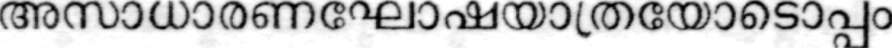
അസാധാരണഘോഷയാത്രയോടൊപ്പം
